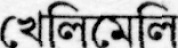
খেলিমেলি
